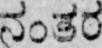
ನಂತರ
